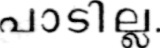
പാടില്ല.
